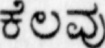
ಕೆಲವು
